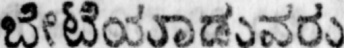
ಬೇಟೆಯಾಡುವರು
